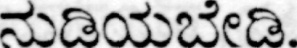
ನುಡಿಯಬೇಡಿ.
